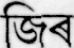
জিৰ
